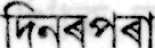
দিনৰপৰা
